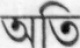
অতি
